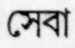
সেবা
